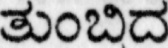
ತುಂಬಿದ
